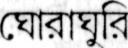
ঘোরাঘুরি
